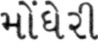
મોંઘેરી
